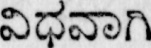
ವಿಧವಾಗಿ
